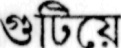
গুটিয়ে
